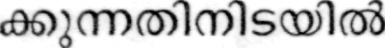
ക്കുന്നതിനിടയില്‍
